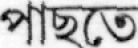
পাছতে
